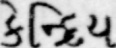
કેન્દ્રિય
